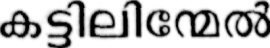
കട്ടിലിന്മേല്‍
